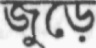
জুড়ে
